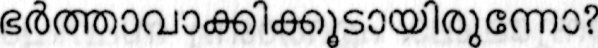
ഭര്‍ത്താവാക്കിക്കൂടായിരുന്നോ?
